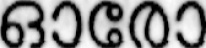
ഓരോ
